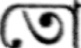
তো
